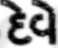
દેવે
